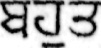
ਬਹੁਤ
